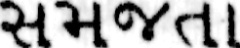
સમજતા
